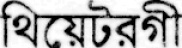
থিয়েটরগী
